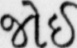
જોઈ
